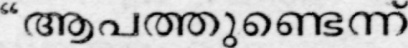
"ആപത്തുണ്ടെന്ന്
